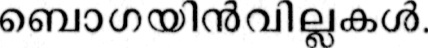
ബൊഗയിന്‍വില്ലകള്‍.
